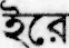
ইরে
